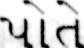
પોતે
